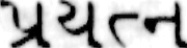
પ્રયત્ન
